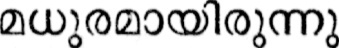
മധുരമായിരുന്നു
